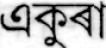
একুৰা
